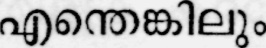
എന്തെങ്കിലും
